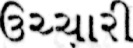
ઉચ્ચારી
